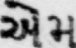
એમ
